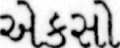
એકસો
